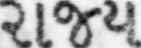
રાજ્ય
